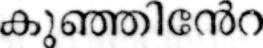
കുഞ്ഞിന്റേ
